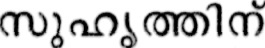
സുഹൃത്തിന്
